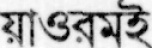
য়াওরমই
